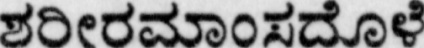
ಶರೀರಮಾಂಸದೊಳೆ
